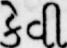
કેવી
